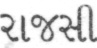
રાજસી
